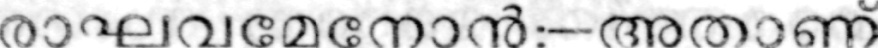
രാഘവമേനോന്‍:-അതാണ്
